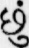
છું
